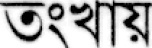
তংখায়
